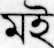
মই
